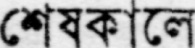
শেষকালে
